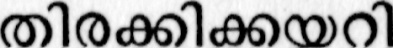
തിരക്കിക്കയറി
